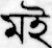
মই
